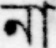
না
